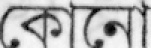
কোনো
